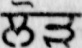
ਲੋੜ
